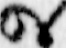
જ
